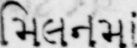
મિલનમાં
